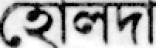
হোলদা
